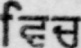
ਵਿਚ
